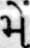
મેં
